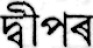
দ্বীপৰ
